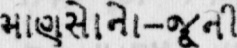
માણસોનો-જૂની
